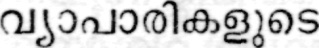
വ്യാപാരികളുടെ
